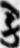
કે
